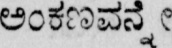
ಅಂಕಣವನ್ನೇ
